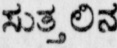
ಸುತ್ತಲಿನ
